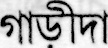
গাড়ীদা
